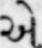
એ
